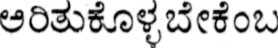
ಅರಿತುಕೊಳ್ಳಬೇಕೆಂಬ
